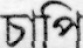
চাপি
